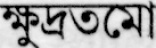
ক্ষুদ্রতমো
